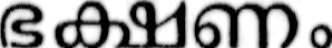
ഭക്ഷണം
